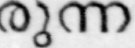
രുന്ന
